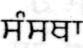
ਸੰਸਥਾ
